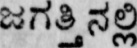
ಜಗತ್ತಿನಲ್ಲಿ
